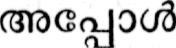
അപ്പോള്‍
